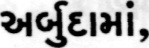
અર્બુદામાં,
